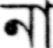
না
